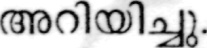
അറിയിച്ചു.
